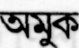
অমুক
